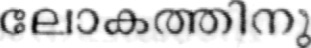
ലോകത്തിനു
